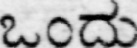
ಒ೦ದು
